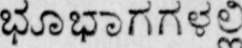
ಭೂಭಾಗಗಳಲ್ಲಿ
